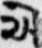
એ
